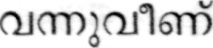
വന്നുവീണ്
